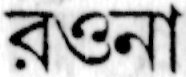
রওনা
